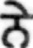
ਨੇ
